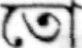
তো
